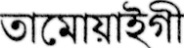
তামোয়াইগী
